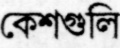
কেশগুলি
